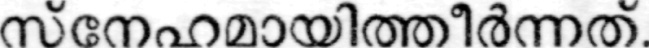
സ്നേഹമായിത്തീര്‍ന്നത്.
